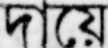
দায়ে
